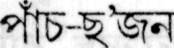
পাঁচ-ছ'জন
